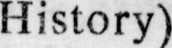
History)
